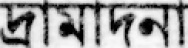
দ্রামাদনা
